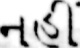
નહીં
